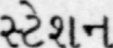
સ્ટેશન
